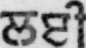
ਲਈ
